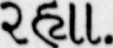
રહ્યા.
